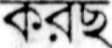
করছ
